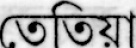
তেতিয়া
